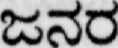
ಜನರ
